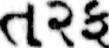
તરફ
